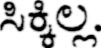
ಸಿಕ್ಕಿಲ್ಲ.
